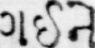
ગઈને
